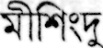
মীশিংদু
